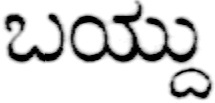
ಬಯ್ದು
